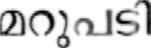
മറുപടി
